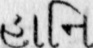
હાનિ
